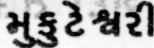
મુકુટેશ્વરી
